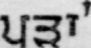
ਪੜਾ'
